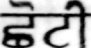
ਛੋਟੀ
